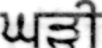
ਘੜੀ
